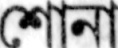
শোনা
